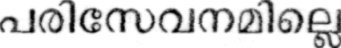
പരിസേവനമില്ലെ
